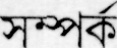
সম্পর্ক
